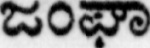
ಜಂಘಾ
